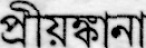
প্রীয়ঙ্কানা
